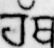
ਹੱਥ
